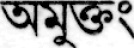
অমুক্তং
